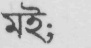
মই;
